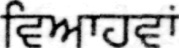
ਵਿਆਹਵਾਂ
